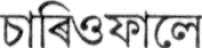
চাৰিওফালে
